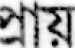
প্ৰায়
